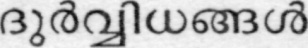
ദുര്‍വ്വിധങ്ങള്‍
